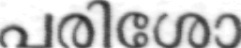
പരിശോ
